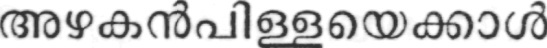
അഴകന്‍പിള്ളയെക്കാള്‍
